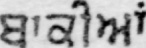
ਬਾਕੀਆਂ
